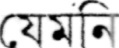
যেমনি
